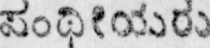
ಪಂಥೀಯರು
